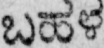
ಬಹಳ
